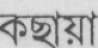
কছায়া
